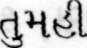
તુમહી
